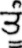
ਤੂੰ
